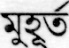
মুহূর্ত
